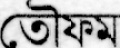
তৌফম
